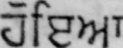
ਹੋਇਆ
